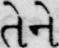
તેને
